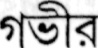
গভীর
